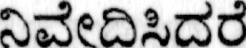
ನಿವೇದಿಸಿದರೆ
